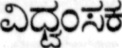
ವಿಧ್ವಂಸಕ
